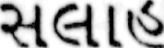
સલાહ
